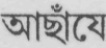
আছাঁযে
